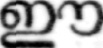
ഈ
